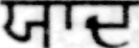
ਯਾਦ
